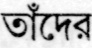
তাঁদের
